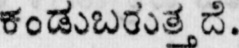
ಕಂಡುಬರುತ್ತದೆ.
